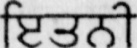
ਇਤਨੀ
